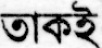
তাকই
